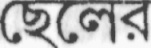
ছেলের
